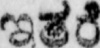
ಇತರೆ
